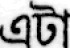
এটা
